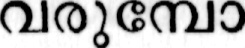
വരുമ്പോ
